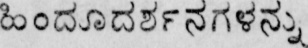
ಹಿಂದೂದರ್ಶನಗಳನ್ನು
